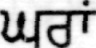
ਘਰਾਂ
